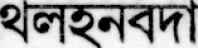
থলহনবদা
